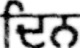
ਦਿਨ
